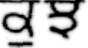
ਕੁਝ
